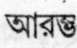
আরম্ভ
